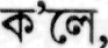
ক'লে,
